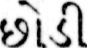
છોડી
